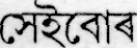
সেইবোৰ
